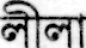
লীলা
